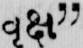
વૃક્ષ”
